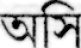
অসি
